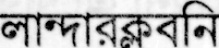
লান্দারক্লবনি
